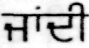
ਜਾਂਦੀ
